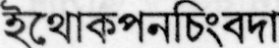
ইথোকপনচিংবদা
